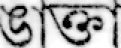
ঙাক্তা
